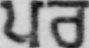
ਪਰ
